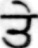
ਤੇ
